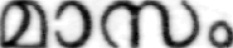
മാസം
